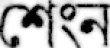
শেংন
